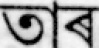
তাৰ
